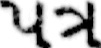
પત્ર
